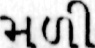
મળી
